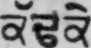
ਕੱਢਕੇ
